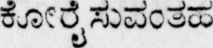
ಕೋರೈಸುವಂತಹ
